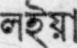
লইয়া
